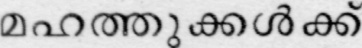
മഹത്തുക്കള്‍ക്ക്
